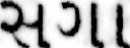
સગા
